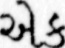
એક
